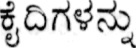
ಕೈದಿಗಳನ್ನು
